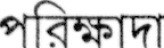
পরিক্ষাদা
